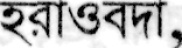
হরাওবদা,
